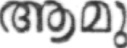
ആമു
